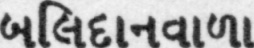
બલિદાનવાળા
